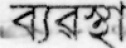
ব্যৱস্থা
